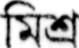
মিশ্র
